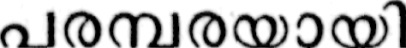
പരമ്പരയായി
